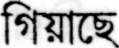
গিয়াছে
